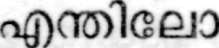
എന്തിലോ
